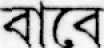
বাবে
